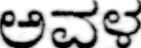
ಅವಳ
